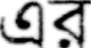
এর
